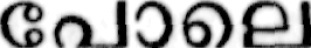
പോലെ
